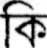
কি
